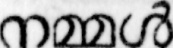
നമ്മള്‍
